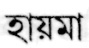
হায়মা
